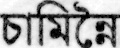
চামিন্নৈ
